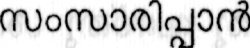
സംസാരിപ്പാന്‍
